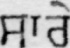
ਸਾਰੇ
